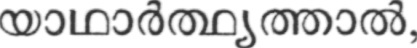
യാഥാര്‍ത്ഥ്യത്താല്‍,
